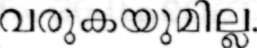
വരുകയുമില്ല.
